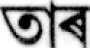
তাৰ
